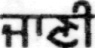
ਜਾਣੀ
